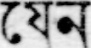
যেন
